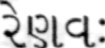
રેણવઃ
